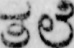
ತಲೆ
